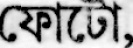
ফোটো,
